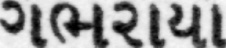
ગભરાયા
